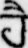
ਹੈ
